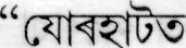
"যোৰহাটত
